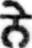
ਨੇ
